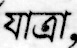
যাত্রা,
